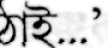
ঠাই...'
